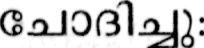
ചോദിച്ചു:
